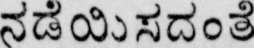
ನಡೆಯಿಸದಂತೆ
